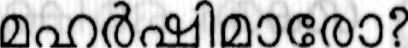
മഹര്‍ഷിമാരോ?
